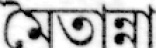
মৈতান্না
